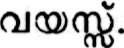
വയസ്സ്.
